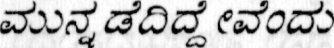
ಮುನ್ನಡೆದಿದ್ದೇವೆಂದು
